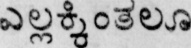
ಎಲ್ಲಕ್ಕಿಂತಲೂ
